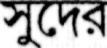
সুদের
